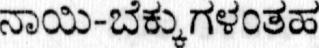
ನಾಯಿ-ಬೆಕ್ಕುಗಳಂತಹ
